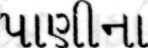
પાણીના
